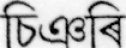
চিঞৰি
